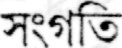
সংগতি
